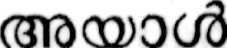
അയാള്‍
